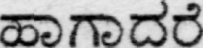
ಹಾಗಾದರೆ
